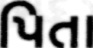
પિતા
